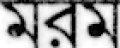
মরম
